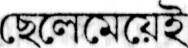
ছেলেমেয়েই
